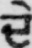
ਦੇ
